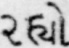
રહ્યો
